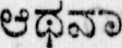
ಆಥವಾ
